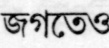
জগতেও
